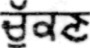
ਚੁੱਕਣ
